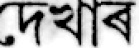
দেখাৰ
